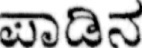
ಪಾಡಿನ
